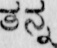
ತನ್ನ
